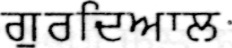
ਗੁਰਦਿਆਲ
